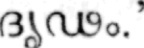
ദൃഢം.'
